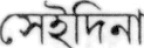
সেইদিনা
